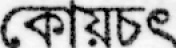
কোয়চৎ
